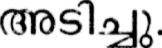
അടിച്ചു.
